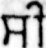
ਸੀ
